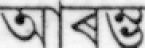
আৰম্ভ
